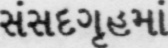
સંસદગૃહમાં
